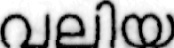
വലിയ
